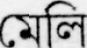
মেলি
